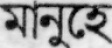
মানুহে
